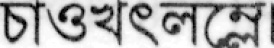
চাওখৎলম্লে।
